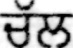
ਚੱਲ
